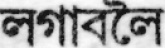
লগাবলৈ
